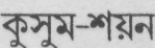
কুসুম-শয়ন
